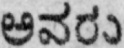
ಅವರು
